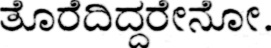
ತೊರೆದಿದ್ದರೇನೋ.
